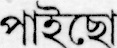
পাইছো
